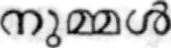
നുമ്മള്‍
